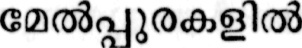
മേല്‍പ്പുരകളില്‍
